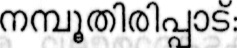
നമ്പൂതിരിപ്പാട്:
